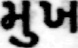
મુખ
